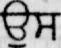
ਉਸ
